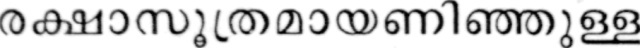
രക്ഷാസൂത്രമായണിഞ്ഞുള്ള
